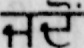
ਜਦੋਂ
